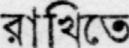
রাখিতে
